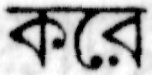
করে
